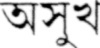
অসুখ
